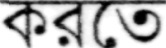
করতে
